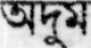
অদুম
